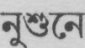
নুশুনে
